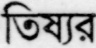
তিষ্যর
